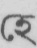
হে
